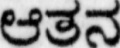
ಆತನ
